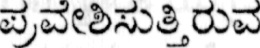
ಪ್ರವೇಶಿಸುತ್ತಿರುವ
